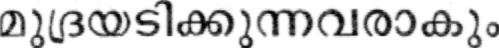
മുദ്രയടിക്കുന്നവരാകും
